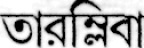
তারম্লিবা
